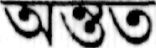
অন্তত
